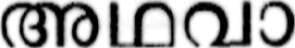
അഥവാ
